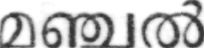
മഞ്ചല്‍
